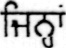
ਜਿਨ੍ਹਾਂ
